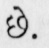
છે.
